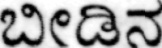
ಬೀಡಿನ
